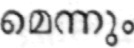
മെന്നും
